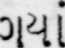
ગયાં
